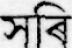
সৰি
